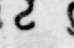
માટે
